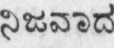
ನಿಜವಾದ
